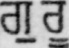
ਗੁਰੂ
